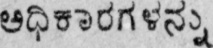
ಅಧಿಕಾರಗಳನ್ನು
